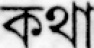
কথা
